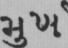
મુર્ખ
